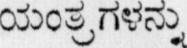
ಯಂತ್ರಗಳನ್ನು
